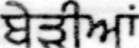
ਬੇੜੀਆਂ
